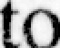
to
